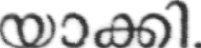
യാക്കി.
